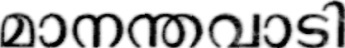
മാനന്തവാടി
